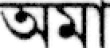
অমা
